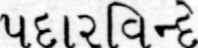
પદારવિન્દં,
